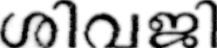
ശിവജി
